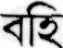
বহি
